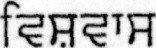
ਵਿਸ਼ਵਾਸ
